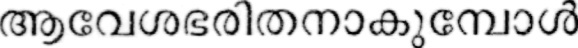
ആവേശഭരിതനാകുമ്പോള്‍
